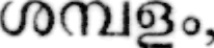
ശമ്പളം,
